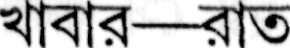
খাবার-রাত
